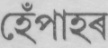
হেঁপাহৰ
